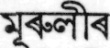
মূৰুলীৰ
